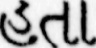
હતા
